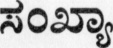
ಸಂಖ್ಯಾ
